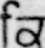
ਕਿ
